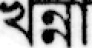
খন্না
